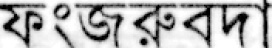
ফংজরুবদা
